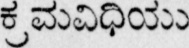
ಕ್ರಮವಿಧಿಯು
